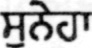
ਸੁਨੇਹਾ
